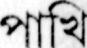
পাখি
